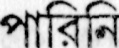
পারিনি
